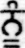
ਨੂੰ
